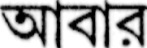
আবার
